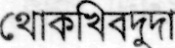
থোকখিবদুদা
